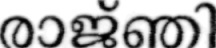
രാജ്ഞി
